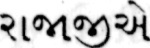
રાજાજીએ
